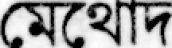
মেথোদ
